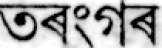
তৰংগৰ
